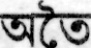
অতৈ
